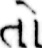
તો
